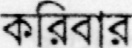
করিবার
